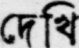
দেখি
